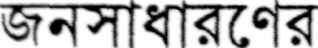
জনসাধারণের
